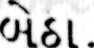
બેઠા.
